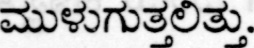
ಮುಳುಗುತ್ತಲಿತ್ತು.
